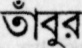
তাঁবুর
